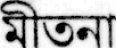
মীতনা
